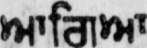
ਆਗਿਆ
